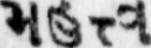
મહત્વ
